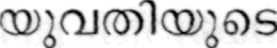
യുവതിയുടെ
